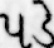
પડે
